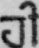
ਹੀ
